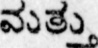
ಮತ್ತು
